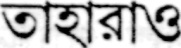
তাহারাও
